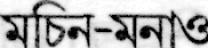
মচিন-মনাও
